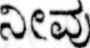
ನೀವು
